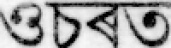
ওচৰত
